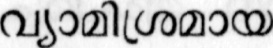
വ്യാമിശ്രമായ
